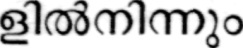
ളില്‍നിന്നും
